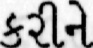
કરીને
